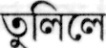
তুলিলে
